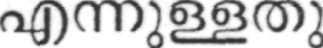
എന്നുള്ളതു
